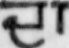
ਦਾ
